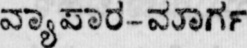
ವ್ಯಾಪಾರ-ಮಾರ್ಗ
